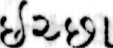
ઈચ્છા
